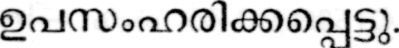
ഉപസംഹരിക്കപ്പെട്ടു.
